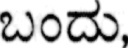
ಬಂದು,
